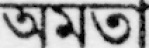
অমতা
